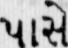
પાસે
